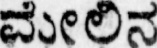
ಮೇಲಿನ
